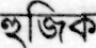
হুজিক
